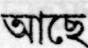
আছে
